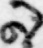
જે
